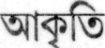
আকৃতি
